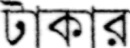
টাকার
